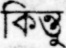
কিন্তু
